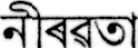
নীৰৱতা
